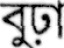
বুঢ়া
